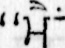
''ਮੈਂ
